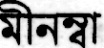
মীনম্বা
